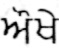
ਔਖੇ
